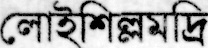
লোইশিল্লমদ্রি
